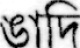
ঙাদি
